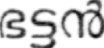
ഭട്ടന്‍
